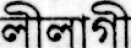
লীলাগী
